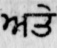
ਅਤੇ
